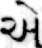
એ
